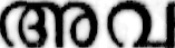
അവ
